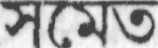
সমেত
